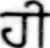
ਹੀ
